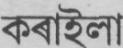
কৰাইলা
